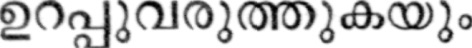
ഉറപ്പുവരുത്തുകയും
